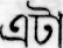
এটা
